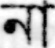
না
